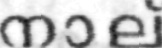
നാല്
